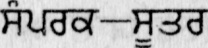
ਸੰਪਰਕ-ਸੂਤਰ
